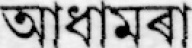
আধামৰা
